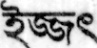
ইজ্জৎ
